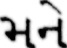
મને
